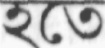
হতে
